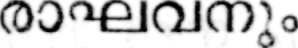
രാഘവനും
